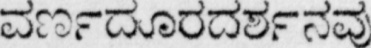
ವರ್ಣದೂರದರ್ಶನವು
